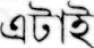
এটাই
